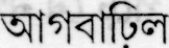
আগবাঢ়িল
